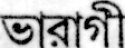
ভারাগী
